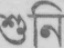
শুনি
